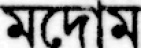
মদোম
